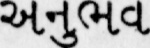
અનુભવ
